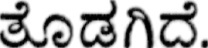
ತೊಡಗಿದೆ.
